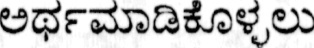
ಅರ್ಥಮಾಡಿಕೊಳ್ಳಲು
